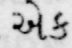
એક
